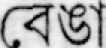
বেঙা
